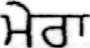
ਮੇਰਾ
